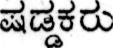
ಷಡ್ಡಕರು
